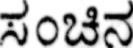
ಸಂಚಿನ
